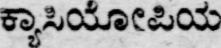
ಕ್ಯಾಸಿಯೋಪಿಯ
